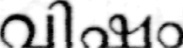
വിഷം
